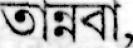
তান্নবা,
